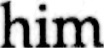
him
